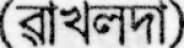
(ৱাখলদা)
